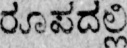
ರೂಪದಲ್ಲಿ
